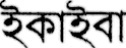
ইকাইবা
